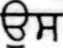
ਉਸ
